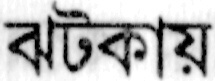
ঝটকায়
